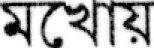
মখোয়
